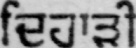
ਦਿਹਾੜੀ
